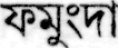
ফমুংদা
